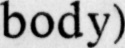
body)
